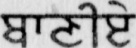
ਬਾਣੀਏ
